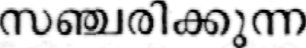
സഞ്ചരിക്കുന്ന
